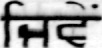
ਜਿਵੇਂ
